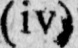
(iv)
